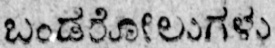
ಬಂಡೆರೋಲುಗಳು
